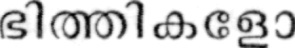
ഭിത്തികളോ
